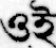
ওই
